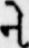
ને
